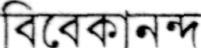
বিবেকানন্দ
